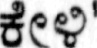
ಕೇಳಿ’
